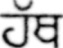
ਹੱਥ
